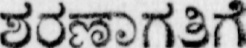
ಶರಣಾಗತಿಗೆ
